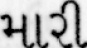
મારી
